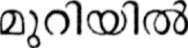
മുറിയില്‍
